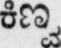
ಕಿಣ್ವ
